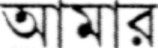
আমার
